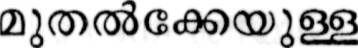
മുതല്‍ക്കേയുള്ള
